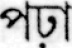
পঢ়া
